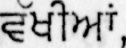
ਵੱਖੀਆਂ,
